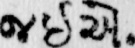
જઈએ.
